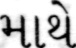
માથે
